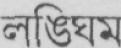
লঙিঘম
